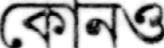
কোনও
